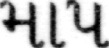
માપ
